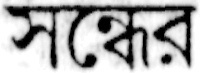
সন্ধের
